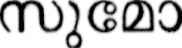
സുമോ
